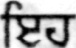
ਇਹ
